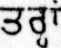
ਤਰ੍ਹਾਂ
